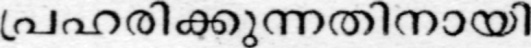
പ്രഹരിക്കുന്നതിനായി
